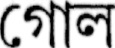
গোল
